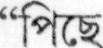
"পিছে
